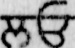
ਲਓ
